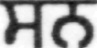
ਸਨ
